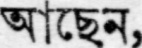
আছেন,
